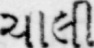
ચાલી
